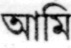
আমি
